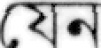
যেন
